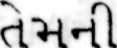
તેમની
